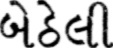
બેઠેલી
